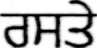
ਰਸਤੇ
